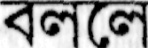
বললে
